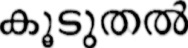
കൂടുതല്‍
